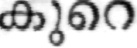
കുറെ
